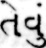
તેવું
